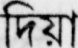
দিয়া
